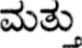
ಮತ್ತು
